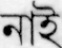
নাই
